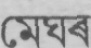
মেঘৰ
